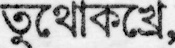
তুথোকখ্রে,
